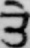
ਤੇ
